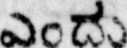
ಎಂದು
